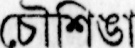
চৌশিঙা
